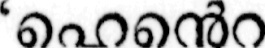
'ഹെൻെറ
